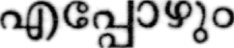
എപ്പോഴും
